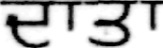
ਦਾਤਾ
